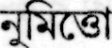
নুমিত্তো
